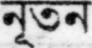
নূতন
